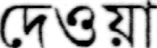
দেওয়া
